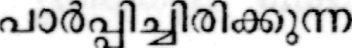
പാര്‍പ്പിച്ചിരിക്കുന്ന
